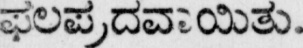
ಫಲಪ್ರದವಾಯಿತು.
